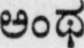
ಅಂಥ
